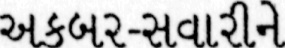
અકબર-સવારીને
